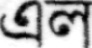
এল
